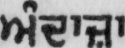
ਅੰਦਾਜ਼ਾ
